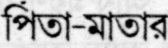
পিতা-মাতার
